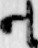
ન
